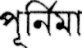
পূর্নিমা
